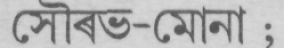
সৌৰভ-মোনা;
